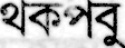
থকপবু
